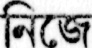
নিজে
